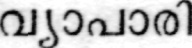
വ്യാപാരി
